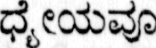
ಧ್ಯೇಯವೂ
